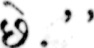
છે."
